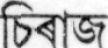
চিৰাজ
